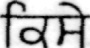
ਕਿਸੇ
